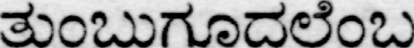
ತುಂಬುಗೂದಲೆಂಬ
